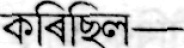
কৰিছিল-
